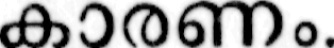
കാരണം.
